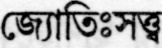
জ্যোতিঃসত্ত্ব
